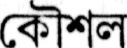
কৌশল
